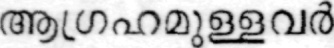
ആഗ്രഹമുള്ളവര്‍
